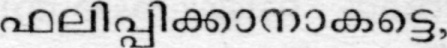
ഫലിപ്പിക്കാനാകട്ടെ,
